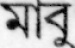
মাবু
